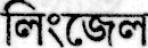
লিংজেল
